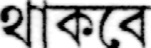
থাকবে
